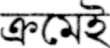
ক্রমেই
